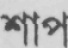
শাপ
